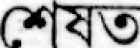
শেষত
